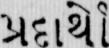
પ્રદાર્થો
